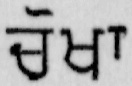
ਚੋਖਾ
